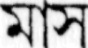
মাস
